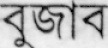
বুজাব
